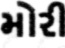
મોરી
